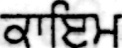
ਕਾਇਮ
